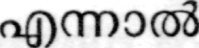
എന്നാല്‍
